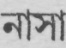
নাসা
